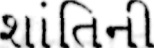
શાંતિની
